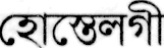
হোস্তেলগী
